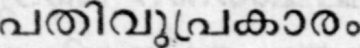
പതിവുപ്രകാരം
